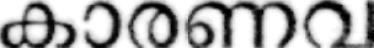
കാരണവ
